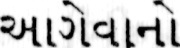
આગેવાનો
